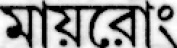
মায়রোং
